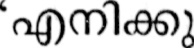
‘എനിക്കു
